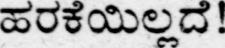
ಹರಕೆಯಿಲ್ಲದೆ!
